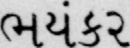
ભયંકર
